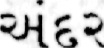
અંદર
